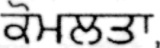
ਕੋਮਲਤਾ,
